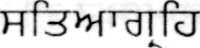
ਸਤਿਆਗ੍ਰਹਿ
